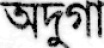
অদুগা
